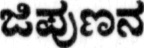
ಜಿಪುಣನ
